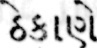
ઠેકાણે
